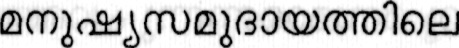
മനുഷ്യസമുദായത്തിലെ
